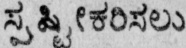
ಸ್ಪಷ್ಟೀಕರಿಸಲು
